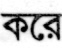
করে
